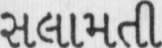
સલામતી
